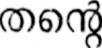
തന്റെ
